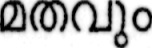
മതവും
